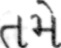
તમે
